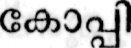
കോപ്പി
